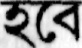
হবে
